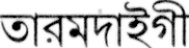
তারমদাইগী
